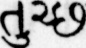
તુચ્છ
